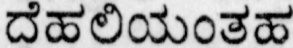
ದೆಹಲಿಯಂತಹ
